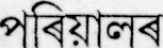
পৰিয়ালৰ
